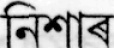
নিশাৰ
